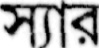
স্যার
